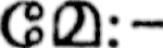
മേ:-
